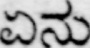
ಏನು
